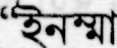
“ইনম্মা
